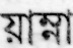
য়াম্না
